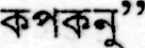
কপকনু”
